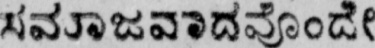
ಸಮಾಜವಾದವೊಂದೇ
